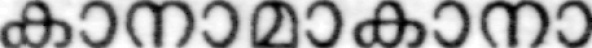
കാനാമാകാനാ
